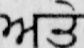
ਅਤੇ
